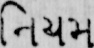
નિયમ
